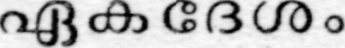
ഏകദേശം
